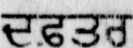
ਦਫ਼ਤਰ
